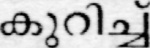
കുറിച്ച്
